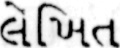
લેખિત
